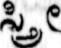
ಸ್ತ್ರೀ
